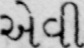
એવી
